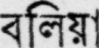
বলিয়া
